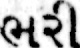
ભરી
